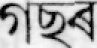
গছৰ
